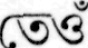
তেওঁ
